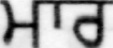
ਮਾਰ
